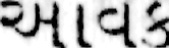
આવક
